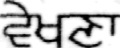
ਵੇਖਣਾ
